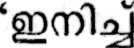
‘ഇനിച്ച്
